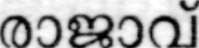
രാജാവ്
